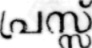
പ്രസ്സ്
